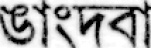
ঙাংদবা
